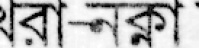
খরা-নক্না
